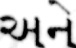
અને
